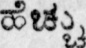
ಹೆಚ್ಚು
